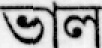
ভাল
